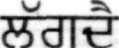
ਲੱਗਦੈ
